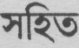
সহিত
